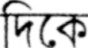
দিকে
